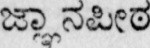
ಜ್ಞಾನಪೀಠ
